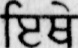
ਇਥੇ
